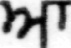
ਆ
